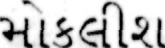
મોકલીશ
